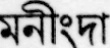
মনীংদা
